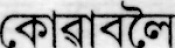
কোৱাবলৈ
